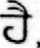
ਹੈ,
